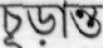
চূড়ান্ত
